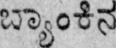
ಬ್ಯಾಂಕಿನ
